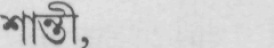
শান্তী,
